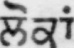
ਲੋਕਾਂ
